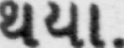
થયા.
